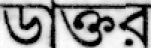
ডাক্তর
